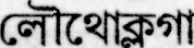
লৌথোক্লগা
